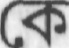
কে
